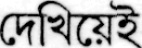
দেখিয়েই
